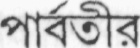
পার্বতীর
